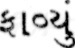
ફાવ્યું
